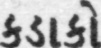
કડાકો
